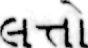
લત્તો
